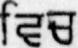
ਵਿਚ
